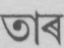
তাৰ
